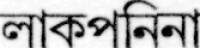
লাকপনিনা
